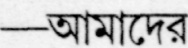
–আমাদের
